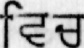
ਵਿਚ
